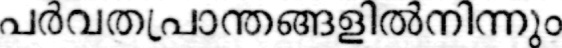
പര്‍വതപ്രാന്തങ്ങളില്‍നിന്നും
